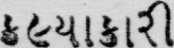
કલ્યાકારી
